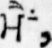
ਮੈਂ,
